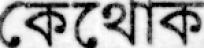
কেথোক
